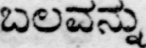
ಬಲವನ್ನು
